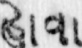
હોવા
